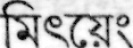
মিৎয়েং
